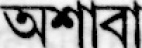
অশাবা
